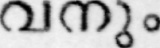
വനും
